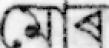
মোৰ
